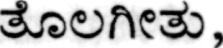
ತೊಲಗೀತು,
